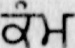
ਕੰਮ
